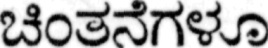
ಚಿಂತನೆಗಳೂ
